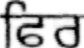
ਫਿਰ
